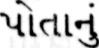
પોતાનું
